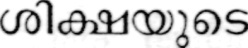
ശിക്ഷയുടെ
